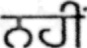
ਨਹੀਂ
